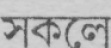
সকলে
